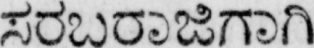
ಸರಬರಾಜಿಗಾಗಿ
